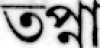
তপ্না
